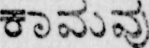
ಕಾಮವು
